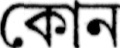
কোন
